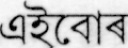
এইবোৰ
